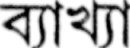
ব্যাখ্যা
